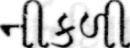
નીકળી
